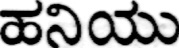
ಹನಿಯು
